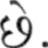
છે.
